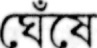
ঘেষেঁ
